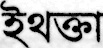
ইথক্তা
